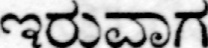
ಇರುವಾಗ
